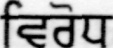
ਵਿਰੋਧ
